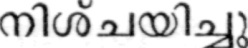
നിശ്ചയിച്ചു
